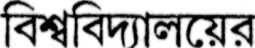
বিশ্ববিদ্যালয়ের
